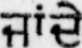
ਜਾਂਦੇ
